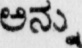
ಅನ್ನು
